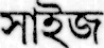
সাইজ
